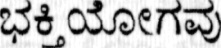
ಭಕ್ತಿಯೋಗವು
